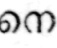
നെ
